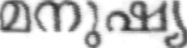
മനുഷ്യ
